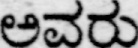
ಅವರು
